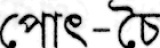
পোৎ-চৈ
